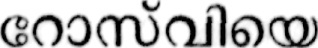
റോസ്വിയെ
